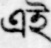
এই
